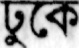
ঢুকে
